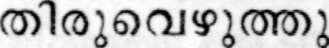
തിരുവെഴുത്തു
